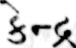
કેન્દ્ર
